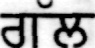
ਗੱਲ
